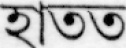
হাতত
